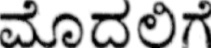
ಮೊದಲಿಗೆ
